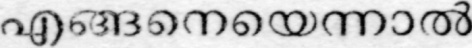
എങ്ങനെയെന്നാല്‍
